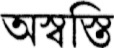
অস্বস্তি
